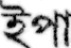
ইপা
